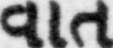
વાત
